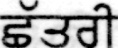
ਛੱਤਰੀ
